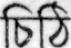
চিঠি
